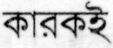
কারকই
